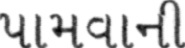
પામવાની
